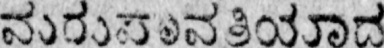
ಮರುಪಾವತಿಯಾದ
